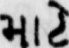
માટે
